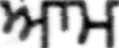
ਆਮ
